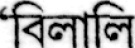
'বিলালি
